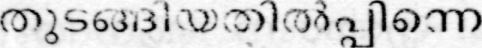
തുടങ്ങിയതില്‍പ്പിന്നെ
